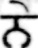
ਨੇ
